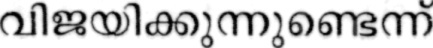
വിജയിക്കുന്നുണ്ടെന്ന്
